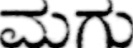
ಮಗು
